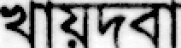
খায়দবা
